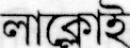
লাক্লোই
